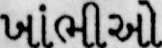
ખાંભીઓ
